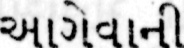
આગેવાની
